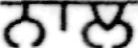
ਨਾਲ
